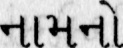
નામનો
